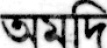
অমদি
